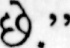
છે."
